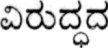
ವಿರುದ್ಧದ
